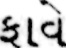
ફાવે
